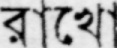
রাখো
